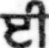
ਈ
